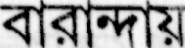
বারান্দায়
